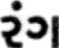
રંગ
